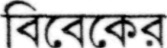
বিবেকের
